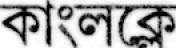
কাংলক্লে
